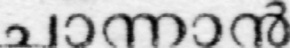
ചാന്നാന്‍
